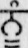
ਨੂੰ
